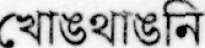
খোঙথাঙনি
